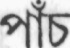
পাঁচ
